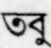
তবু
